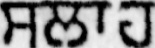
ਸਲਾਹ
